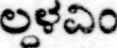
ಲ್ದಳವಿ೦
